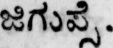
ಜಿಗುಪ್ಸೆ.
